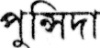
পুন্সিদা
